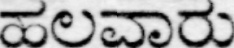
ಹಲವಾರು
